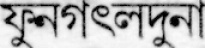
ফুনগৎলদুনা
